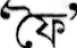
‘ফৈ’
